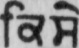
ਕਿਸੇ
